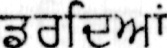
ਡਰਦਿਆਂ
